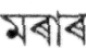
মৰাৰ
